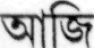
আজি
